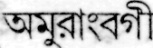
অমুরাংবগী
